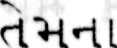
તેમના
